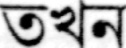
তখন
